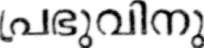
പ്രഭുവിനു
